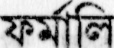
ফর্মালি
